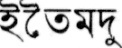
ইতৈমদু
